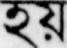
হয়
